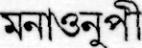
মনাওনুপী
